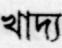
খাদ্য
